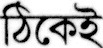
ঠিকেই
